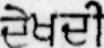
ਦੇਖਦੀ
